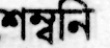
শেম্বনি
